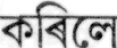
কৰিলে
